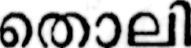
തൊലി
